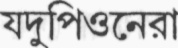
যদুপিওনেরা
